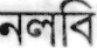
নলবি
